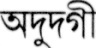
অদুদগী
